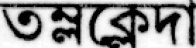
তম্লক্লেদা
